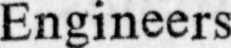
Engineers
